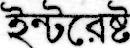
ইন্টরেষ্ট
